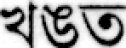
খঙত
